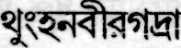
থুংহনবীরগদ্রা
